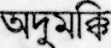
অদুমক্কি
